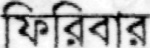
ফিরিবার
